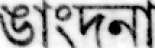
ঙাংদনা
